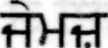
ਜੇਮਜ਼
